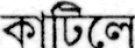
কাটিলে
